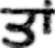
ਤਾਂ
